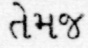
તેમજ
